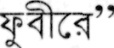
ফুবীরে”
